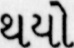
થયો
